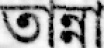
তান্না
